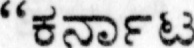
“ಕರ್ನಾಟ
